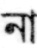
না
